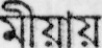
মীয়ায়
